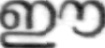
ഈ
